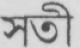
সতী
